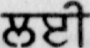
ਲਈ
